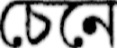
চেনে
